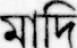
মাদি
